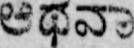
ಅಥವಾ
